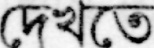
দেখতে
